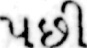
પછી
